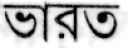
‘ভারত
